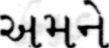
અમને
